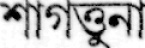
শাগত্তুনা
